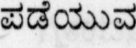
ಪಡೆಯುವ
